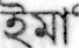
ইমা‘
